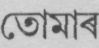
তোমাৰ
